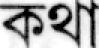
কথা
